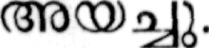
അയച്ചു.
